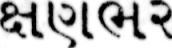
ક્ષણભર
